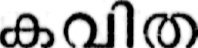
കവിത
